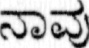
ನಾವು
